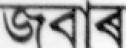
জবাৰ
